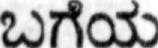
ಬಗೆಯ
